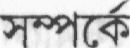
সম্পর্কে
